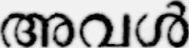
അവള്‍
